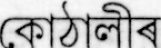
কোঠালীৰ
